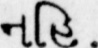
નહિ.
